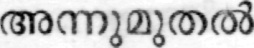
അന്നുമുതല്‍
